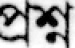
প্রশ্ন
